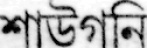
শাউগনি
